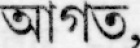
আগত,
